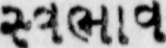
સ્વભાવ
